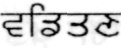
ਵਡਿਤਣ
